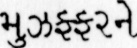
મુઝફ્ફરને
